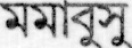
মমাবুসু
